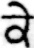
ਕੇ
